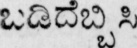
ಬಡಿದೆಬ್ಬಿಸಿ
